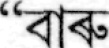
"বাৰু
